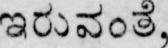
ಇರುವಂತೆ,
